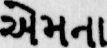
એમના
